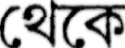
থেকে
